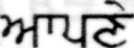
ਆਪਣੇ
